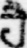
ਹੈ
